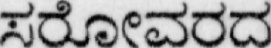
ಸರೋವರದ
